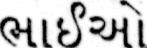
ભાઈઓ
